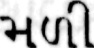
મળી
